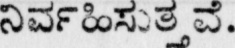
ನಿರ್ವಹಿಸುತ್ತವೆ.
